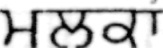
ਮਲਕਾਂ
